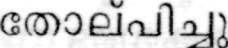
തോല്പിച്ചു
